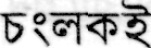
চংলকই
